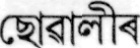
ছোৱালীৰ
